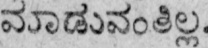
ಮಾಡುವಂತಿಲ್ಲ.
